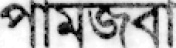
পামজবা
